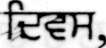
ਦਿਵਸ,
